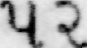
પર
